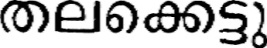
തലക്കെട്ടു
